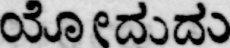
ಯೋದುದು
